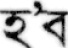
হ'ব
